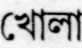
খোলা
